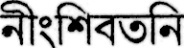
নীংশিবতনি
